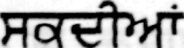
ਸਕਦੀਆਂ
